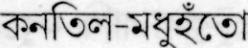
কনতিল-মধুহঁতো
